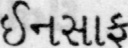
ઇનસાફ
